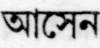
আসেন
